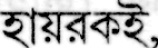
হায়রকই,
